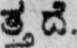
ತ್ತದೆ.
